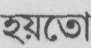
হয়তো
